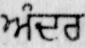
ਅੰਦਰ
